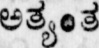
ಅತ್ಯಂತ
